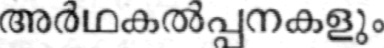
അര്‍ഥകല്‍പ്പനകളും
